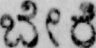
ಬೇರೆ
